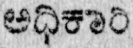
ಅಧಿಕಾರಿ
